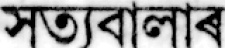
সত্যবালাৰ
